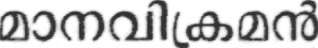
മാനവിക്രമന്‍
